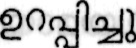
ഉറപ്പിച്ചു
